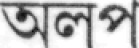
অলপ
